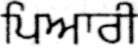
ਪਿਆਰੀ
